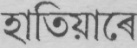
হাতিয়াৰে
